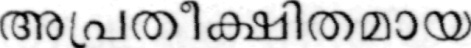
അപ്രതീക്ഷിതമായ
